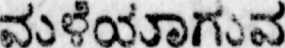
ಮಳೆಯಾಗುವ
